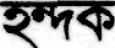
হন্দক
